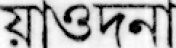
য়াওদনা
